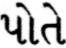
પોતે
